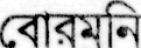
বোরমনি
